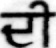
ਦੀ
